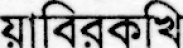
য়াবিরকখি
